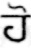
ਹੋ
